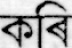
কৰি
